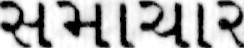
સમાચાર
